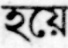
হয়ে
